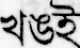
খঙই
